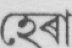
হেৰা
